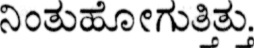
ನಿಂತುಹೋಗುತ್ತಿತ್ತು.
